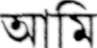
আমি
